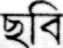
ছবি
